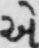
એ
